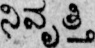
ನಿವೃತ್ತಿ
